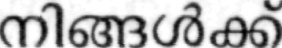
നിങ്ങള്‍ക്ക്
